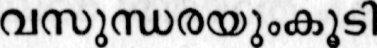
വസുന്ധരയുംകൂടി
